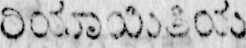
ರಿಯಾಯಿತಿಯ
